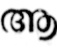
ആ
